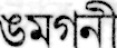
ঙমগনী
